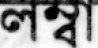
লম্বা
